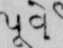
પૂર્વે
